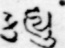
કહ્યું
